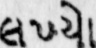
લખ્યો
